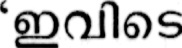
‘ഇവിടെ
